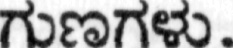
ಗುಣಗಳು.
